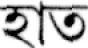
হাত
